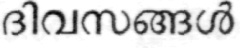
ദിവസങ്ങള്‍
